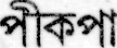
পীকপা
